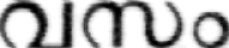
വസം
